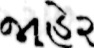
જાહેર
